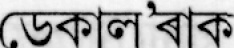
ডেকাল'ৰাক
